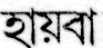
হায়বা
